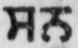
ਸਨ
